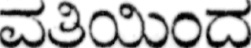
ವತಿಯಿಂದ
